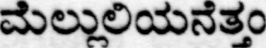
ಮೆಲ್ಲುಲಿಯನೆತ್ತಂ
